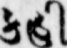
કહી
